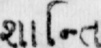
શાન્તિ
